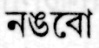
নঙবো
